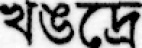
খঙদ্রে
